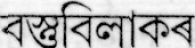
বস্তুবিলাকৰ
